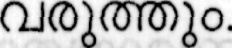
വരുത്തും.
